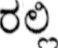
ರಲ್ಲಿ
